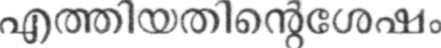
എത്തിയതിന്റെശേഷം
